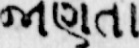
જાણતા
